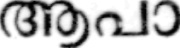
ആപാ
